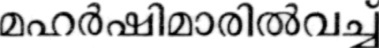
മഹര്‍ഷിമാരില്‍വച്ച്
